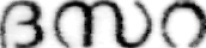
ദസറ
